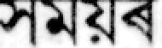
সময়ৰ
